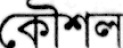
কৌশল
